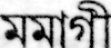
মমাগী
